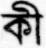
কী
